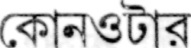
কোনওটার
